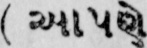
(આપણે
